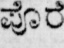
ಪೊರೆ
